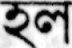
হল
